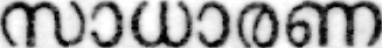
സാധാരണ
